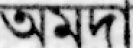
অমদা
